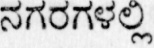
ನಗರಗಳಲ್ಲಿ
